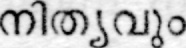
നിത്യവും
